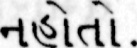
નહોતો.
